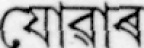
যোৱাৰ
